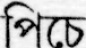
পিচে
